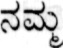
ನಮ್ಮ
